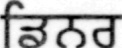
ਡਿਨਰ
